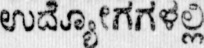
ಉದ್ಯೋಗಗಳಲ್ಲಿ
